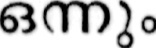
ഒന്നും
